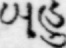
બહુ
